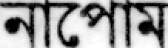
নাপোম
